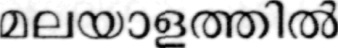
മലയാളത്തില്‍
